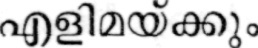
എളിമയ്ക്കും
